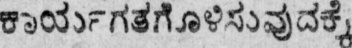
ಕಾರ್ಯಗತಗೊಳಿಸುವುದಕ್ಕೆ
